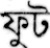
ফুট
